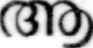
ആ
